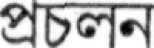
প্রচলন
